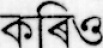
কৰিও
